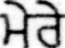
ਮੇਰੇ
